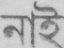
নাই
